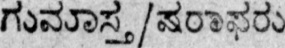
ಗುಮಾಸ್ತ/ಷರಾಫರು
